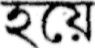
হয়ে
